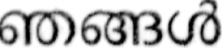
ഞങ്ങള്‍
